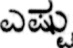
ಎಷ್ಟು
